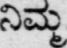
ನಿಮ್ಮ
